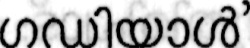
ഗഡിയാള്‍'
